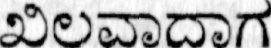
ಖಿಲವಾದಾಗ
